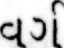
વર્ગ
